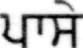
ਪਾਸੇ
